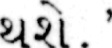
થશે.'
